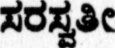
ಸರಸ್ವತೀ
